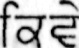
ਕਿਵੇ
